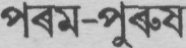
পৰম-পুৰুষ
